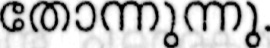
തോന്നുന്നു.
